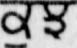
ਕੁਝ
